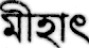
মীহাৎ
